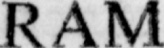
RAM
